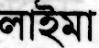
লাইম
